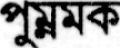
পুম্নমক
